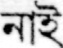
নাই
